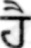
ਹੈ
